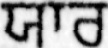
ਯਾਰ
